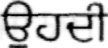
ਉਹਦੀ
